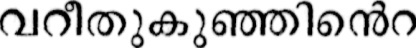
വറീതുകുഞ്ഞിന്റെ
